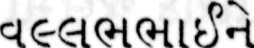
વલ્લભભાઈને
